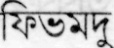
ফিবমদু
